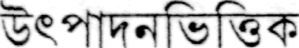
উত্পাদনভিত্তিক
